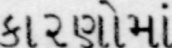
કારણોમાં
